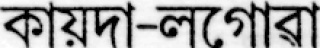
কায়দা-লগোৱা
